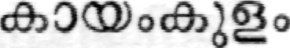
കായംകുളം
